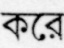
করে
